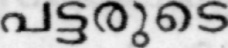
പട്ടരുടെ
